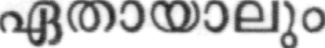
ഏതായാലും
